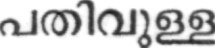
പതിവുള്ള
